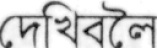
দেখিবলৈ
